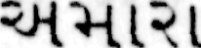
અમારા
